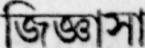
জিজ্ঞাসা
